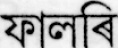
ফালৰি
